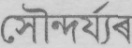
সৌন্দৰ্য্যৰ
